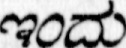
ಇಂದು
